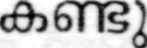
കണ്ടു
